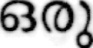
ഒരു
